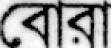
বোরা
